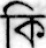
কি
